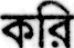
করি
